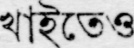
খাইতেও
